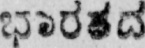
ಭಾರತದ
